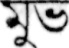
মুভ
